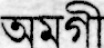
অমগী
